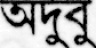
অদুবু
